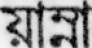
য়াম্না
